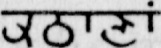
ਕਠਾਣਾਂ
